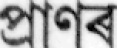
প্রাণৰ
